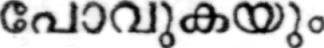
പോവുകയും
